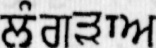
ਲੰਗੜਾਅ
